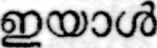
ഇയാള്‍
